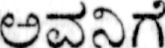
ಅವನಿಗೆ
